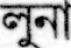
লুনা
